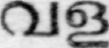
വള
